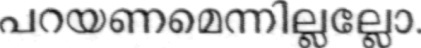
പറയണമെന്നില്ലല്ലോ.
